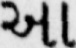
આ
